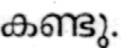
കണ്ടു.
